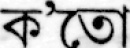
ক'তো
